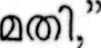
മതി,"
